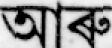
আৰু
